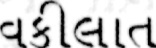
વકીલાત
